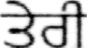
ਤੇਰੀ
